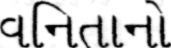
વનિતાનો
